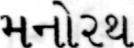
મનોરથ
